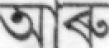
আৰু
